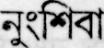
নুংশিবা
